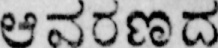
ಆವರಣದ
